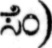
ಸೆಂ)
